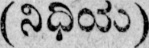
(ನಿಧಿಯ)
